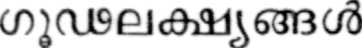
ഗൂഢലക്ഷ്യങ്ങള്‍
